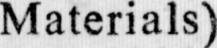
Materials)
